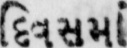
દિવસમાં
